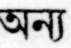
অন্য
